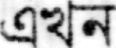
এখন
